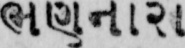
ભણનારા
